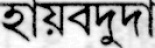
হায়বদুদা
